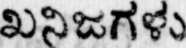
ಖನಿಜಗಳು
